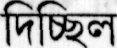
দিচ্ছিল
